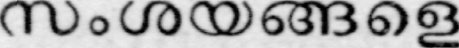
സംശയങ്ങളെ
